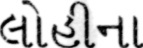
લોહીના
